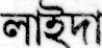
লাইদা
